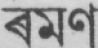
ৰমণ
